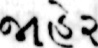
જાહેર
